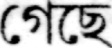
গেছে
